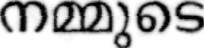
നമ്മുടെ
